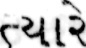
ત્યારે
